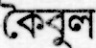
কৈবুল
